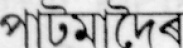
পাটমাদৈৰ
